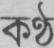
কণ্ঠ
